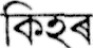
কিহৰ
